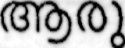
ആരു
